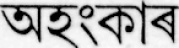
অহংকাৰ
